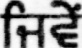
ਜਿਵੇਂ
